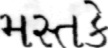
મસ્તકે
